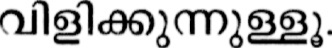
വിളിക്കുന്നുള്ളൂ.
